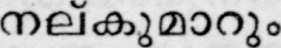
നല്കുമാറും
